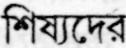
শিষ্যদের
